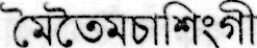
মৈতৈমচাশিংগী
